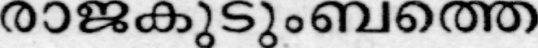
രാജകുടുംബത്തെ
